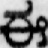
ಈ
